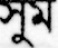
সুম
